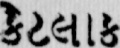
કેટલાક
